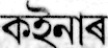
কইনাৰ
